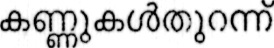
കണ്ണുകള്‍തുറന്ന്
